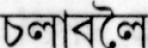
চলাবলৈ
